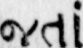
જતાં
